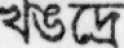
খঙদ্রে
